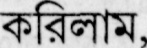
করিলাম,
